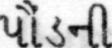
પૌડની
